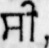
ਸੀ।
